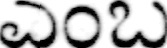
ಎಂಬ
